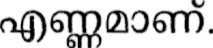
എണ്ണമാണ്.
